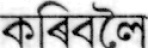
কৰিবলৈ
